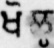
ਖੋਲ੍ਹ
